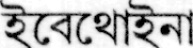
ইবেথোইনা
